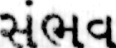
સંભવ
